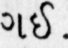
ગઈ.
